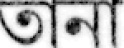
তানা
